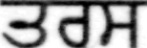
ਤਰਸ
